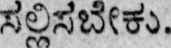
ಸಲ್ಲಿಸಬೇಕು.
